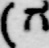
(ಗ
